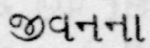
જીવનના
